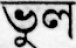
ভুল
